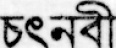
চৎনবী
